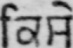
ਕਿਸੇ
